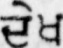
ਦੇਖ
